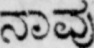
ನಾವು
